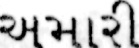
અમારી
